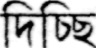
দিচ্ছি
